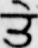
ਤੇ
